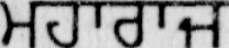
ਮਹਾਰਾਜ
